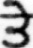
ਤੇ
